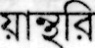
য়ান্থরি
